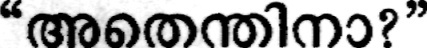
“അതെന്തിനാ?"
